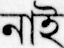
নাই
